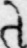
તે
